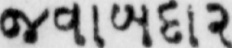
જવાબદાર
